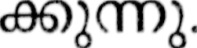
ക്കുന്നു.
